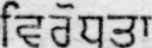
ਵਿਰੋਧਤਾ
